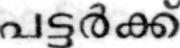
പട്ടര്‍ക്ക്
